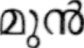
മുന്‍
